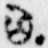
છે.
